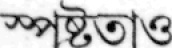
স্পষ্টতাও
